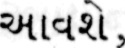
આવશે,
